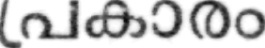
പ്രകാരം
